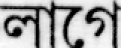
লাগে
